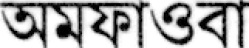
অমফাওবা
